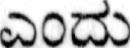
ಎಂದು
